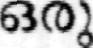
ഒരു
